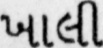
ખાલી
